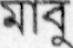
মাবু
